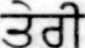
ਤੇਰੀ
